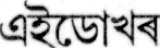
এইডোখৰ
